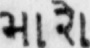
મારો
